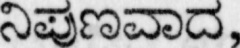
ನಿಪುಣನಾದ,
